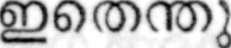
ഇതെന്തു
